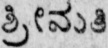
ಶ್ರೀಮತಿ
